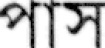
পাস
